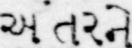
અંતરને
